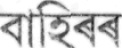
বাহিৰৰ
